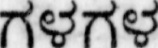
ಗಳಗಳ
